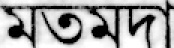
মতমদা
